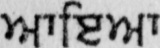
ਆਇਆ
